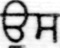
ਉਸ
